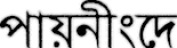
পায়নীংদে
